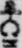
ਨੂੰ
